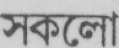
সকলো
